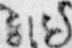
કોઈ
